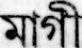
মাগী
